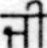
ਜੀ
